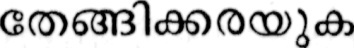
തേങ്ങിക്കരയുക
